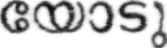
യോടു
